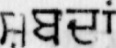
ਸ਼ਬਦਾਂ
